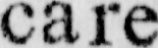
care
